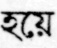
হয়ে
